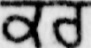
ਕਰ
